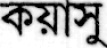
কয়াসু
